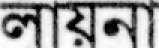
লায়না
